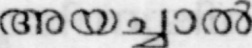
അയച്ചാല്‍
